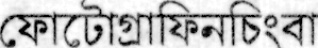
ফোটোগ্রাফিনচিংবা
